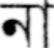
না
